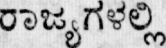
ರಾಜ್ಯಗಳಲ್ಲಿ
